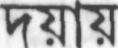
দয়ায়
